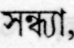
সন্ধ্যা,
